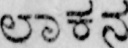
ಲಾಕನ
